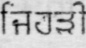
ਜਿਹੜੀ
